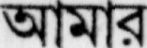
আমার
